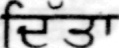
ਦਿੱਤਾ
